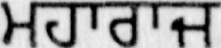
ਮਹਾਰਾਜ
